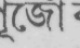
পূজো
